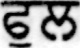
ਫੁਲ
